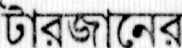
টারজানের
